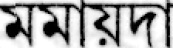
মমায়দা
